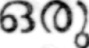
ഒരു
